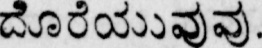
ದೊರೆಯುವುವು.
